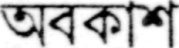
অবকাশ
